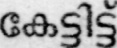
കേട്ടിട്ട്
